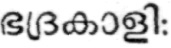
ഭദ്രകാളി:
